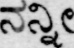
ನನ್ನೀ
